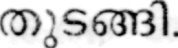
തുടങ്ങി.
